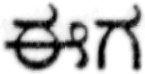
ಈಗ
